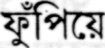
ফুপিয়ে
